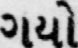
ગયો
